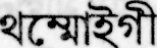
থম্মোইগী
